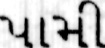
પામી
